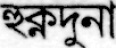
হুক্নদুনা
